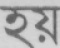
হয়
